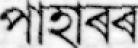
পাহাৰৰ
